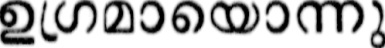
ഉഗ്രമായൊന്നു
